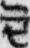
ਦੋ
